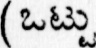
(ಒಟ್ಟು
